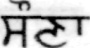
ਸੌਣਾ
